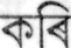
কৰি
